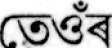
তেওঁৰ
